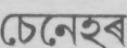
চেনেহৰ
